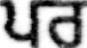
ਪਰ
